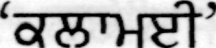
'ਕਲਾਮਈ'
